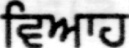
ਵਿਆਹ
